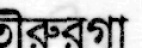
লৈশেম্বা
